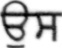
ਉਸ
